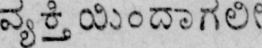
ವ್ಯಕ್ತಿಯಿಂದಾಗಲೀ
